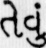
તેવું
